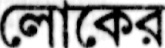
লোকের
